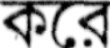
করে
